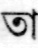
তা
